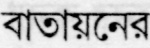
বাতায়নের
